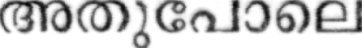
അതുപോലെ
